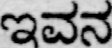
ಇವನ
